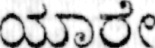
ಯಾರೇ
